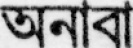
অনাবা
